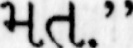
મત."
